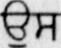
ਉਸ
